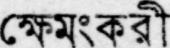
ক্ষেমংকরী
